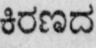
ಕಿರಣದ
